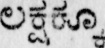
ಲಕ್ಷಕ್ಕೂ
